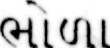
ભોળા
